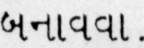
બનાવવા.
